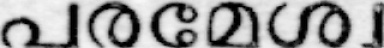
പരമേശ്വ
